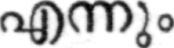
എന്നും
